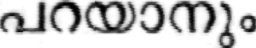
പറയാനും
